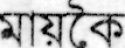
মায়কৈ
